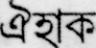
ঐহাক
